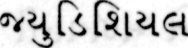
જ્યુડિશિયલ
